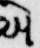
એ
